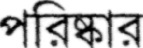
পরিষ্কার
